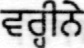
ਵਰ੍ਹੀਨੇ
